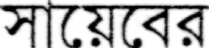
সায়েবের
